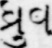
ધ્રુવ
